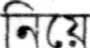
নিয়ে
